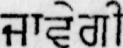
ਜਾਵੇਗੀ
